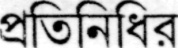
প্রতিনিধির
